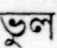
ভুল
